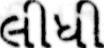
લીધી
